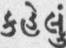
કહેલું
